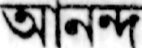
আনন্দ
